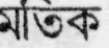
মতিক
